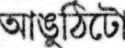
আঙুঠিটো
